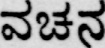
ವಚನ
